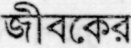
জীবকের
